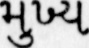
મુખ્ય
